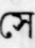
সে
